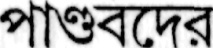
পাণ্ডবদের
